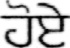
ਹੋਏ
